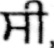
ਸੀ,
